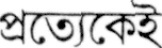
প্রত্যেকেই
